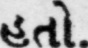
હતો.
